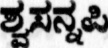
ಶ್ವಸನ್ನಪಿ
